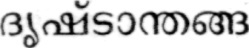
ദൃഷ്ടാന്തങ്ങ
